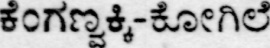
ಕೆಂಗಣ್ವಕ್ಕಿ-ಕೋಗಿಲೆ
